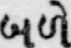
બળે
